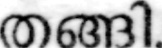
തങ്ങി.
